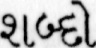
શબ્દો
